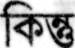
কিন্তু
